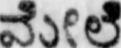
ಮೇಲೆ
